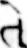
તે
